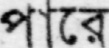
পারে
